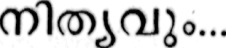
നിത്യവും...
